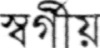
স্বর্গীয়
